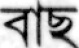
বাছ
